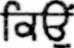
ਕਿਉਂ
